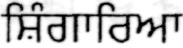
ਸ਼ਿੰਗਾਰਿਆ
